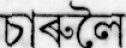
চাৰুলৈ
